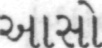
આસો
